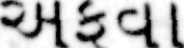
અફવા
